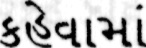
કહેવામાં
